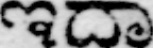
ಇದಾ
